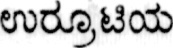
ಉರ್ರೂಟಿಯ
